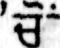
'ਚੋਂ
